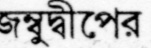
জম্বুদ্বীপের
